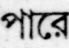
পারে
